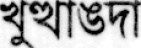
খুত্থাঙদা
